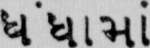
ધંધામાં
